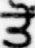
ਤੋਂ
